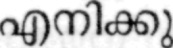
എനിക്കു
